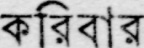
করিবার
